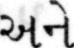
અને
